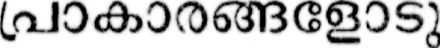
പ്രാകാരങ്ങളോടു
